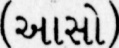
(આસો)
